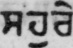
ਸਹੁਰੇ
